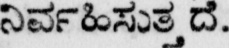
ನಿರ್ವಹಿಸುತ್ತದೆ.
